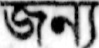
জন্য
